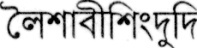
লৈশাবীশিংদুদি
